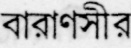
বারাণসীর
